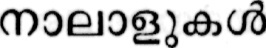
നാലാളുകള്‍
